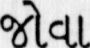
જોવા
